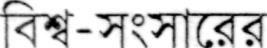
বিশ্ব-সংসারের
